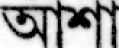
আশা
